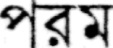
পরম
